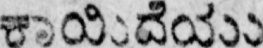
ಕಾಯಿದೆಯು
